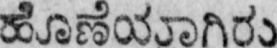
ಹೊಣೆಯಾಗಿರು
